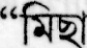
"মিছা
